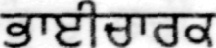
ਭਾਈਚਾਰਕ
